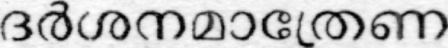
ദര്‍ശനമാത്രേണ
